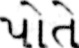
પોતે
